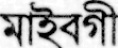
মাইবগী
